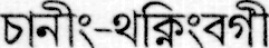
চনীং-থক্নিংবগী
